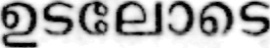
ഉടലോടെ
